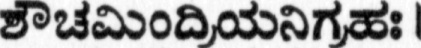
ಶೌಚಮಿಂದ್ರಿಯನಿಗ್ರಹಃ
